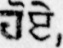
ਹੋਏ,
